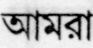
আমরা
